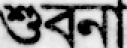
শুবনা
